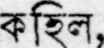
কহিল,
